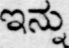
ಇನ್ನು
